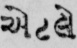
એટલે
